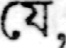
যে,
